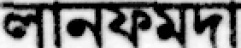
লানফমদা
